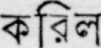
করিল
